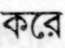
করে
